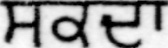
ਸਕਦਾ
